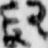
દૂર
